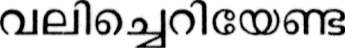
വലിച്ചെറിയേണ്ട
